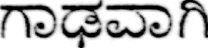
ಗಾಢವಾಗಿ
